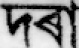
দৰা
